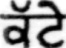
ਕੱਟੇ
